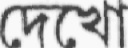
দেখো
